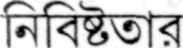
নিবিষ্টতার
